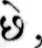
છે,
